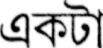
একটা
